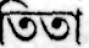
তিতা
